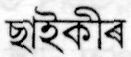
ছাইকীৰ
